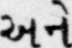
અને
